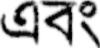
এবং
